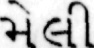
મેલી
